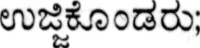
ಉಜ್ಜಿಕೊಂಡರು;
